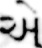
એ
